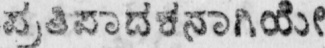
ಪ್ರತಿಪಾದಕನಾಗಿಯೇ
